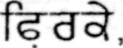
ਫ਼ਿਰਕੇ,
